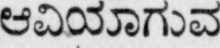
ಆವಿಯಾಗುವ
